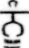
ਨੂੰ
